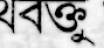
থবক্তু
